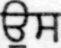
ਉਸ
